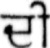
ਦੀ
